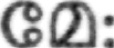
മേ:
